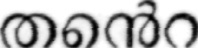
തന്റെ
